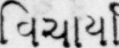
વિચાર્યા
